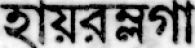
হায়রম্লগা
